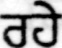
ਰਹੇ
